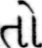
તો
